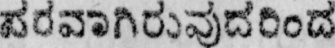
ಪರವಾಗಿರುವುದರಿಂದ
